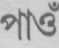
পাওঁ
